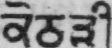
ਕੋਠੜੀ
